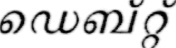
ഡെബ്റ്റ്
